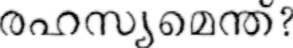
രഹസ്യമെന്ത്?
